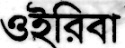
ওইরিবা
